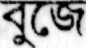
বুজে
